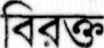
বিরক্ত
